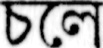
চলে
